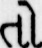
તો
